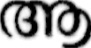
ആ
